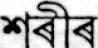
শৰীৰ
